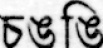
চঙঙি
